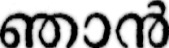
ഞാന്‍
